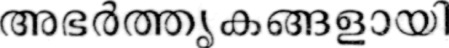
അഭര്‍ത്തൃകങ്ങളായി
